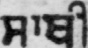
ਸਾਥੀ
